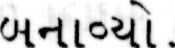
બનાવ્યો.
